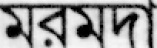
মরমদা
